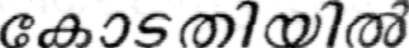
കോടതിയില്‍
